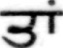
ਤਾਂ
